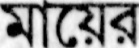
মায়ের
